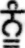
ਨੂੰ
